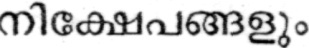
നിക്ഷേപങ്ങളും
